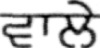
ਵਾਲੇ
